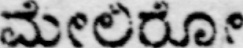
ಮೇಲಿರೋ
